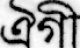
ঐগী
